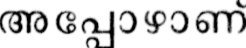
അപ്പോഴാണ്
